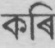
কৰি
